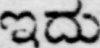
ಇದು
